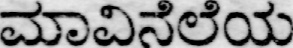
ಮಾವಿನೆಲೆಯ
